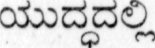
ಯುದ್ಧದಲ್ಲಿ
